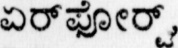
ಏರ್‌ಫೋರ್‍ಟ್,
